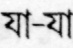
যা-যা
